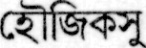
হৌজিকসু
